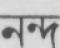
নন্দ
